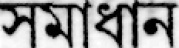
সমাধান
